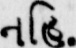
નહિ.
